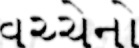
વચ્ચેનો
